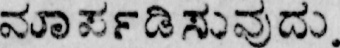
ಮಾರ್ಪಡಿಸುವುದು.
